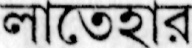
লাতেহার
